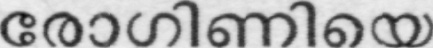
രോഗിണിയെ
